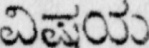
ವಿಷಯ
